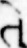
તે
